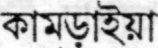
কামড়াইয়া
